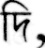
দি,
